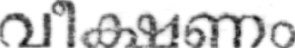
വീക്ഷണം
